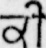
ਕੀ
